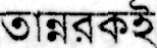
তান্নরকই
